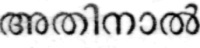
അതിനാല്‍
